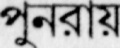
পুনরায়
